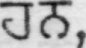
ਹਨ,
